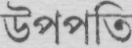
উপপতি
